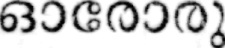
ഓരോരു
